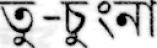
তু-চুংনা
